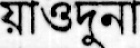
য়াওদুনা
